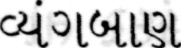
વ્યંગબાણ
